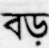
বড়
